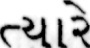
ત્યારે
